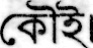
কৌই।
